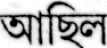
আছিল
